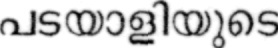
പടയാളിയുടെ
